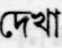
দেখা
